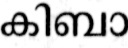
കിബാ
